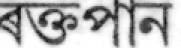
ৰক্তপান
